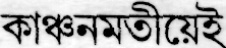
কাঞ্চনমতীয়েই
